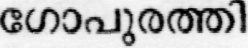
ഗോപുരത്തി
